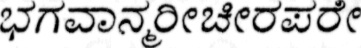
ಭಗವಾನ್ಮರೀಚೀರಪರೇ
